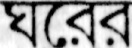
ঘরের
